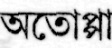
অতোপ্পা
